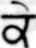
ਕੇ
